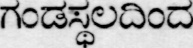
ಗಂಡಸ್ಥಲದಿಂದ
